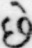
છે
